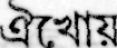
ঐখোয়
